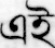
এই
